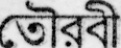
তৌরবী
